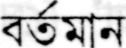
বর্তমান
